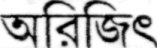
অরিজিৎ
